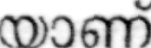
യാണ്
